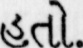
હતો
